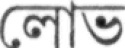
লোভ
